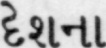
દેશના
